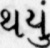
થયું
